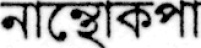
নান্থোকপা
